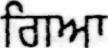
ਗਿਆ
